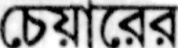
চেয়ারের
